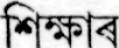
শিক্ষাৰ
